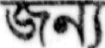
জন্য
